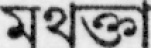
মথক্তা
